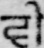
ਵੀ
